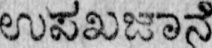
ಉಪಖಜಾನೆ
